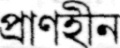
প্রাণহীন
